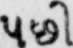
પછી
